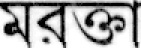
মরক্তা
